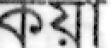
কয়া
